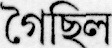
গৈছিল
